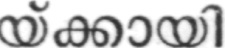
യ്ക്കായി
